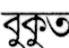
বুকুত
